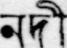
নদী
